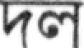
দল
